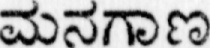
ಮನಗಾಣ
